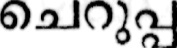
ചെറുപ്പ
